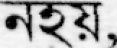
নহয়,
